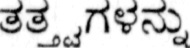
ತತ್ತ್ವಗಳನ್ನು
